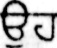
ਉਹ
